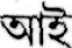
আই
